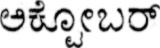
ಅಕ್ಟೋಬರ್
